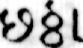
છઠ્ઠા
